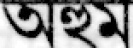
অহুম
